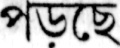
পড়ছে
